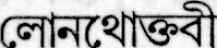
লোনথোক্তবী
